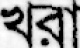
খরা
